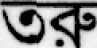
তরু
